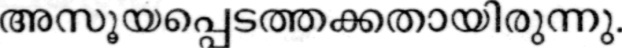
അസൂയപ്പെടത്തക്കതായിരുന്നു.
